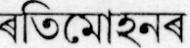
ৰতিমোহনৰ
